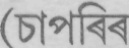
(চাপৰিৰ
